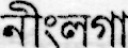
নীংলগা
